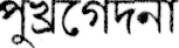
পুখ্রগেদনা
